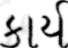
કાર્ય
